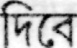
দিবে
